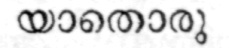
യാതൊരു
